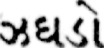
ઝઘડો
